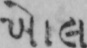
ખોલ
